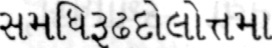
સમધિરૂઢદોલોત્તમા
